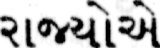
રાજ્યોએ
